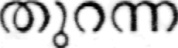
തുറന്ന
